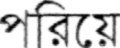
পরিয়ে
